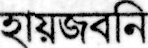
হায়জবনি
